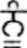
ਨੂੰ
